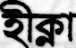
হীক্না
